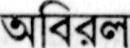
অবিরল
